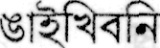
ঙাইখিবনি
